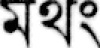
মথং
